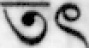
তৎ
